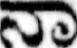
ನಾ
